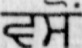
ਵਸੋਂ
